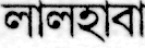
লালহাবা
